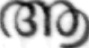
ആ
